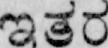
ಇತರ
